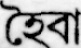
হৈবা
